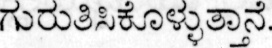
ಗುರುತಿಸಿಕೊಳ್ಳುತ್ತಾನೆ.
